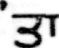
'ਤਾ
